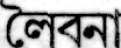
লৈবনা
